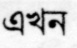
এখন
